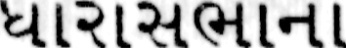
ધારાસભાના
